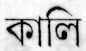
কালি
